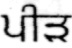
ਪੀੜ
